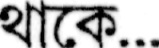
থাকে...
